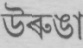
উৰুঙা
